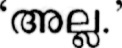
'അല്ല.'
